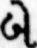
બે
